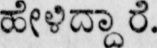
ಹೇಳಿದ್ದಾರೆ.
